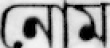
নোম
